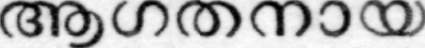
ആഗതനായ
